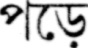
পড়ে
